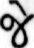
જે
